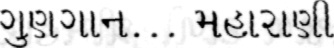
ગુણગાન...મહારાણી
